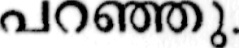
പറഞ്ഞു.
